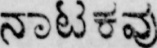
ನಾಟಕವು
